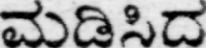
ಮಡಿಸಿದ
